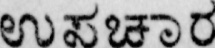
ಉಪಚಾರ
